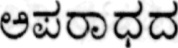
ಅಪರಾಧದ
